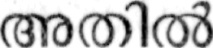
അതില്‍
